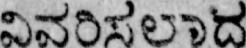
ವಿವರಿಸಲಾದ
